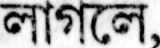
লাগলে,
